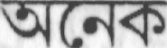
অনেক
